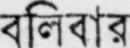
বলিবার
